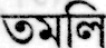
তমলি
